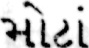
મોટાં
